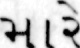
મારે
